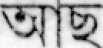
আছ
